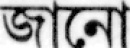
জানো
